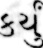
કર્યું
